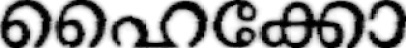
ഹൈക്കോ
